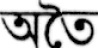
অতৈ
